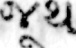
જૂથ
